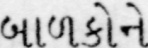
બાળકોને
